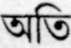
অতি
